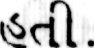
હતી.
